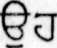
ਉਹ
